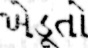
ખેડૂતો
